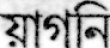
য়াগনি
